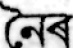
নৈৰ
